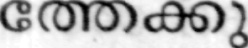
ത്തേക്കു
